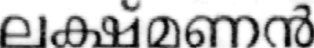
ലക്ഷ്മണന്‍
